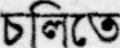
চলিতে
